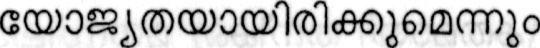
യോജ്യതയായിരിക്കുമെന്നും
